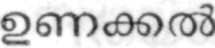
ഉണക്കല്‍
